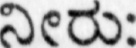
ನೀರು:
